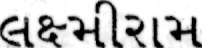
લક્ષ્મીરામ
